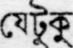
যেটুকু
